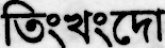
তিংখংদো
